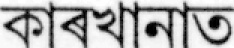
কাৰখানাত
